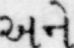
અને
